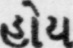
હોય
